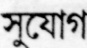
সুযোগ
